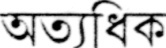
অত্যধিক
